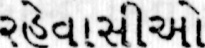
રહેવાસીઓ
